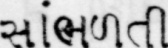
સાંભળતી
